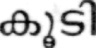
കൂടി
